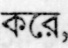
করে,
